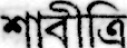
শাবীত্রি
